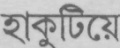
হাকুটিয়ে
